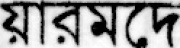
য়ারমদে
